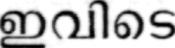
ഇവിടെ
